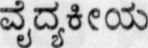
ವೈದ್ಯಕೀಯ
